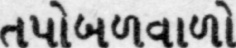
તપોબળવાળો
